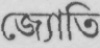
জ্যোতি
